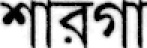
শারগা
